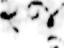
રજુ
